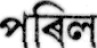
পৰিল
